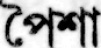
পৈশা
